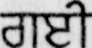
ਗਈ
